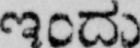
ಇಂದು
